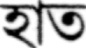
হাত
